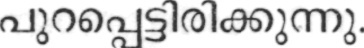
പുറപ്പെട്ടിരിക്കുന്നു.
